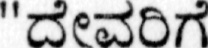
“ದೇವರಿಗೆ
